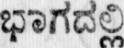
ಭಾಗದಲ್ಲಿ
